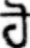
ਹੋ
